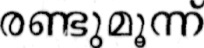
രണ്ടുമൂന്ന്
